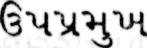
ઉપપ્રમુખ
